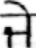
ਜੇ
